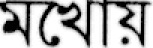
মখোয়
